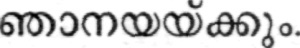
ഞാനയയ്ക്കും.
